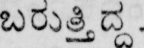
ಬರುತ್ತಿದ್ದ.
